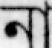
না
